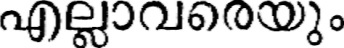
എല്ലാവരെയും
